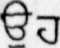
ਉਹ
